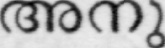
അനു
